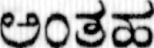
ಅಂತಹ
